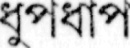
ধুপধাপ
